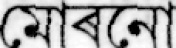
মোৰনো
